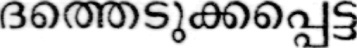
ദത്തെടുക്കപ്പെട്ട
